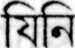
যিনি
